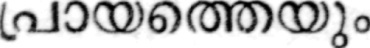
പ്രായത്തെയും
